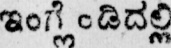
ಇಂಗ್ಲೆಂಡಿದಲ್ಲಿ
